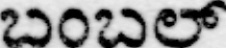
ಬಂಬಲ್
